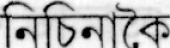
নিচিনাকৈ
